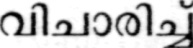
വിചാരിച്ച്
